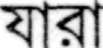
যারা
